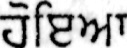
ਹੋਇਆ
